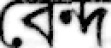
বেন্দ
